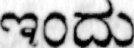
ಇಂದು
